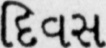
દિવસ
